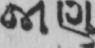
જાણ
